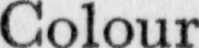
Colour
